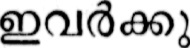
ഇവര്‍ക്കു
